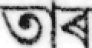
তাৰ
